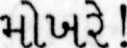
મોખરે!
